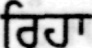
ਰਿਹਾ
